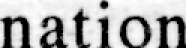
nation
